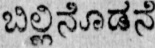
ಬಿಲ್ಲಿನೊಡನೆ
